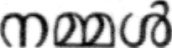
നമ്മള്‍
